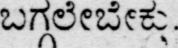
ಬಗ್ಗಲೇಬೇಕು.
